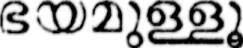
ഭയമുള്ളൂ
